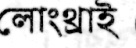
লোংথ্রাই
